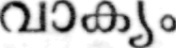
വാക്യം
